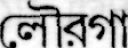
লৌরগা
